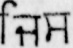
ਜਿਸ
